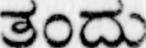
ತಂದು
